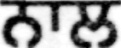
ਨਾਲ
